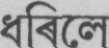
ধৰিলে
